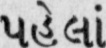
પહેલાં
